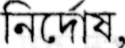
নির্দোষ,
